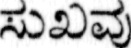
ಸುಖವು
